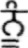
ਨੂੰ
